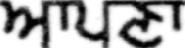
ਆਪਣਾ
